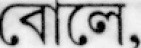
বোলে,
